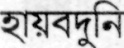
হায়বদুনি
